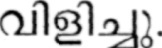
വിളിച്ചു.
